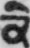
ਕੇ
